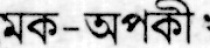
মেক-অপকী
